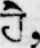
ਹੈ,
